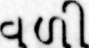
વળી
